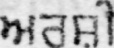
ਅਰਸ਼ੀ
